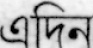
এদিন
